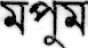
মপুম
